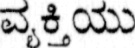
ವ್ಯಕ್ತಿಯು
